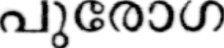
പുരോഗ
